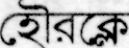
হৌরক্লে
